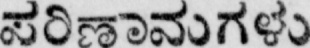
ಪರಿಣಾಮಗಳು
